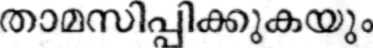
താമസിപ്പിക്കുകയും
